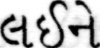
લઈને
